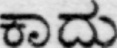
ಕಾದು
